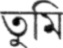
তুমি
